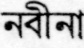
নবীনা
